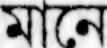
মানে
